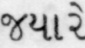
જ્યારે
